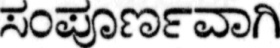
ಸಂಪೂರ್ಣವಾಗಿ
